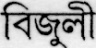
বিজুলী
